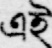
এই
